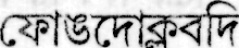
ফোঙদোক্লবদি
